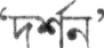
'দর্শন'
